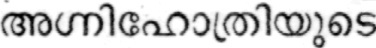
അഗ്നിഹോത്രിയുടെ
